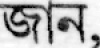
জান,
